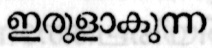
ഇരുളാകുന്ന
